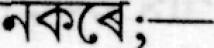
নকৰে;-
